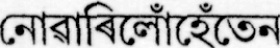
নোৱাৰিলোঁহেঁতেন
